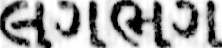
લગભગ
